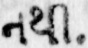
નથી.
